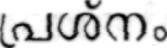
പ്രശ്നം
